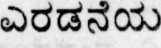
ಎರಡನೆಯ
